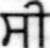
ਸੀ
